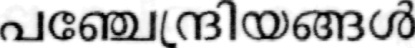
പഞ്ചേന്ദ്രിയങ്ങള്‍
